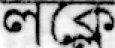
লাক্লে
